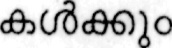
കള്‍ക്കും
